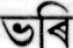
ভৰি
